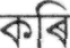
কৰি
